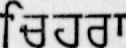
ਚਿਹਰਾ
